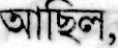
আছিল,
